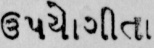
ઉપયોગીત
